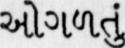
ઓગળતું
